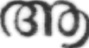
ആ
